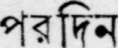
পরদিন
